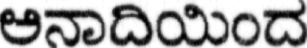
ಅನಾದಿಯಿಂದ
